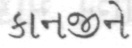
કાનજીને
